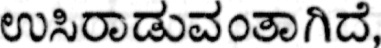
ಉಸಿರಾಡುವಂತಾಗಿದೆ,
